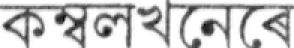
কম্বলখনেৰে
